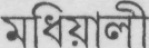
মধিয়ালী
